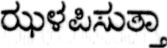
ಝುಳಪಿಸುತ್ತಾ
